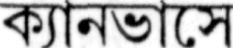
ক্যানভাসে
